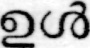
ഉള്‍
